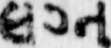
લગ્ન
